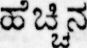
ಹೆಚ್ಚಿನ
